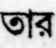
তার
